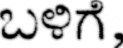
ಬಳಿಗೆ,
